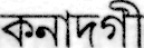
কনাদগী
